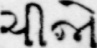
ચીજો
